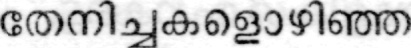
തേനിച്ചകളൊഴിഞ്ഞ
